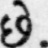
છે.
